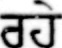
ਰਹੇ
